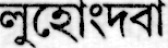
লুংহোদবা
